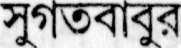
সুগতবাবুর
